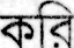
করি
